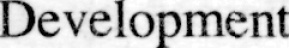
Development
